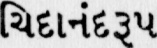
ચિદાનંદરૂપ
